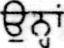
ਉਨ੍ਹਾਂ
